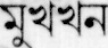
মুখখন
